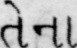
તેના
